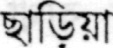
ছাড়িয়া
